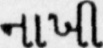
નાખી
